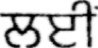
ਲਈਂ
